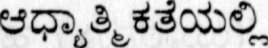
ಆಧ್ಯಾತ್ಮಿಕತೆಯಲ್ಲಿ
